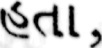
હતા,
